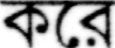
করে
